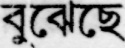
বুঝেছে
